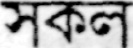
সকল
